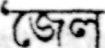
‘জেল
